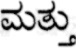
ಮತ್ತು
